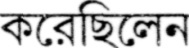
করেছিলেন
